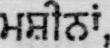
ਮਸ਼ੀਨਾਂ,
